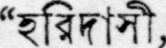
‘‘হরিদাসী,
